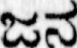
ಜನ
